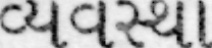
વ્યવસ્થા
